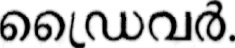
ഡ്രൈവര്‍.
